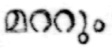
മററും
